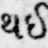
થઈ
